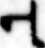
ન
